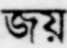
জয়
